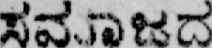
ಸಮಾಜದ
